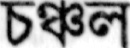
চঞ্চল
